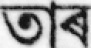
তাৰ
